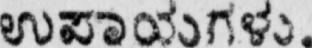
ಉಪಾಯಗಳು.
